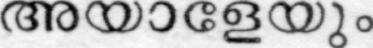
അയാളേയും
